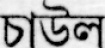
চাউল
